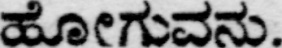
ಹೋಗುವನು.
